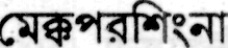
মেক্কপরশিংনা
